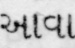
આવા
